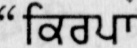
''ਕਿਰਪਾ
